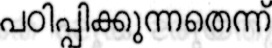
പഠിപ്പിക്കുന്നതെന്ന്
